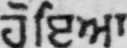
ਹੋਇਆ
